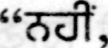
''ਨਹੀਂ,
